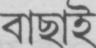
বাছাই
